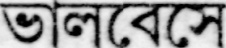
ভালবেসে
